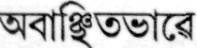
অবাঞ্ছিতভাৱে
